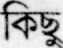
কিছু
